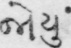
જોયું
